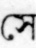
সে
